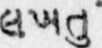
લખતું
